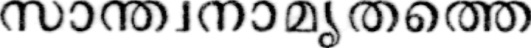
സാന്ത്വനാമൃതത്തെ
